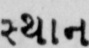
સ્થાન
